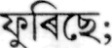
ফুৰিছে;
